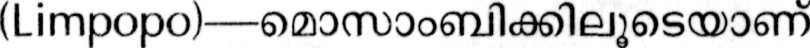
(Limpopo)-മൊസാംബിക്കിലൂടെയാണ്
